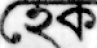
হেক
